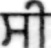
ਸੀ
